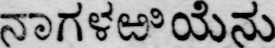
ನಾಗಳಱಿಯೆನು
